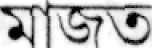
মাজত
